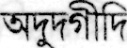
অদুদগীদি
